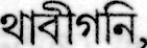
থাবীগনি,
